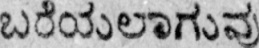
ಬರೆಯಲಾಗುವು
